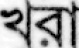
খরা
